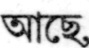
আছে,
